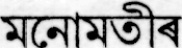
মনোমতীৰ
